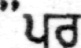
''ਪਰ
